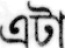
এটা
